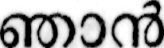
ഞാന്‍
